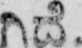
ಗಿದೆ.
